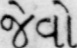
જેવો
